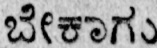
ಬೇಕಾಗು
